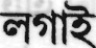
লগাই
